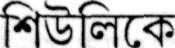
শিউলিকে
